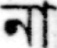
না
